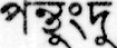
পন্থুংদু
